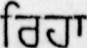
ਰਿਹਾ
